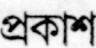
প্রকাশ
